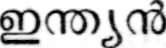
ഇന്ത്യന്‍
